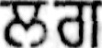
ਲਗ
